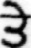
ਤੇ
